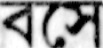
বসে
